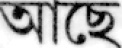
আছে
